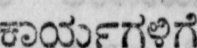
ಕಾರ್ಯಗಳಿಗೆ
